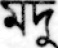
মদু
